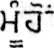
ਮੂੰਹੋਂ
